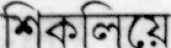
শিকলিয়ে
